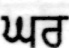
ਘਰ
